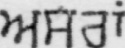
ਅਸਰਾਂ
